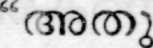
"അതു
